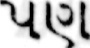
પણ
